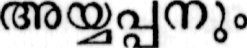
അയ്യപ്പനും
